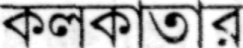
কলকাতার
